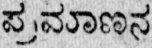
ಪ್ರಮಾಣನ
